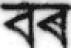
বৰ
